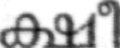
ക്ഷീ
